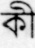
কী
